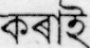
কৰাই
